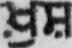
ਖ਼ੁਸ਼
